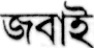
জবাই
